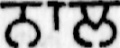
ਨਾਲ
